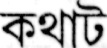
কথাট
